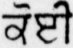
ਕੋਈ
